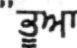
''ਭੂਆ
